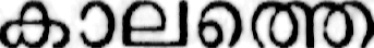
കാലത്തെ
